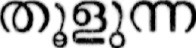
തൂളുന്ന
